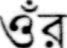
ওঁর
